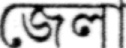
জেলা
